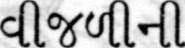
વીજળીની
